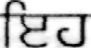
ਇਹ
